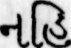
નહિ
